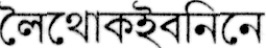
লৈথোকইবনিনে
